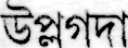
উপ্লগদা
